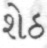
શેઠ
